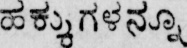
ಹಕ್ಕುಗಳನ್ನೂ
